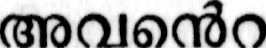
അവന്റെ
